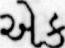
એક
